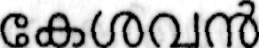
കേശവന്‍
